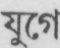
যুগে
